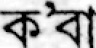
ক'বা
